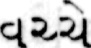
વચ્ચે
